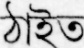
ঠাইত
